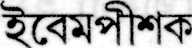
ইবেমপীশক
